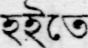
হইতে
